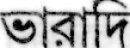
ভারাদি
